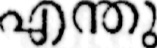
എന്തു
